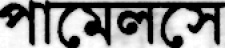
পামেলসে
